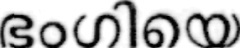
ഭംഗിയെ
